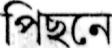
পিছনে
